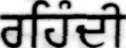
ਰਹਿੰਦੀ
